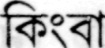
কিংবা
